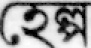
হেল্প
